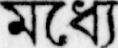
মধ্যে
